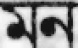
মন
